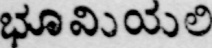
ಭೂಮಿಯಲಿ
